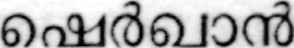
ഷെര്‍ഖാന്‍
